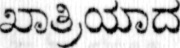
ಖಾತ್ರಿಯಾದ
